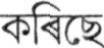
কৰিছে
